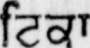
ਟਿਕਾ
